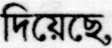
দিয়েছে,
